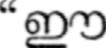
“ഈ
